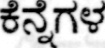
ಕೆನ್ನೆಗಳ
